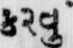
કરવું
